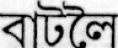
বাটলৈ
